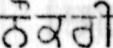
ਨੌਕਰੀ
